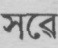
সৱে
